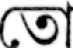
তো
